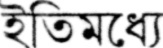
ইতিমধ্যে
